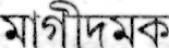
মাগীদমক
